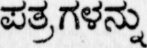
ಪತ್ರಗಳನ್ನು
